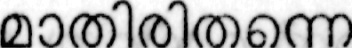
മാതിരിതന്നെ
